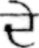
ਦੇ
